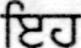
ਇਹ
